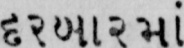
દરબારમાં
